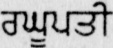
ਰਘੂਪਤੀ
